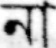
না
